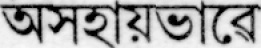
অসহায়ভাৱে
